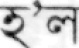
হ'ল
